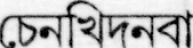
চেনখিদনবা
